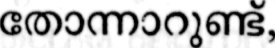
തോന്നാറുണ്ട്,
